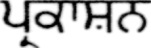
ਪ੍ਰਕਾਸ਼ਨ
